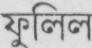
ফুলিল
